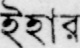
ইহার
